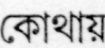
কোথায়
